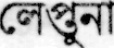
লেপ্তুনা
